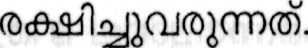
രക്ഷിച്ചുവരുന്നത്.
